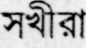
সখীরা
